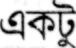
একটু
